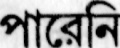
পারেনি
